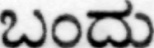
ಬಂದು
